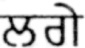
ਲਗੇ
